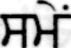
ਸਮੇਂ
